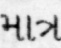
માત્ર
